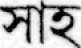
সাহ
